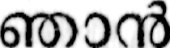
ഞാന്‍
